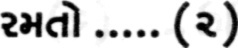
રમતો.......(૨)
